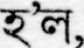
হ'ল,
